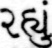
રહ્યું
